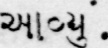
આવ્યું.
